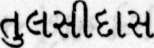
તુલસીદાસ
